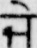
ਜੇ
